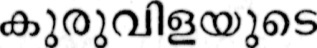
കുരുവിളയുടെ
